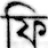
ফি
